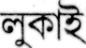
লুকাই
